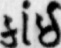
કાંઈ
